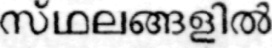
സ്ഥലങ്ങളില്‍
